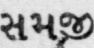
સમજી
